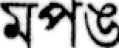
মপঙ
